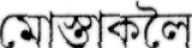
মোস্তাকলৈ
